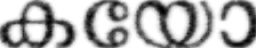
കയോ
